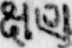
ક્ષણ
